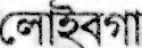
লৌইবগা
